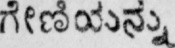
ಗೇಣಿಯನ್ನು
